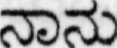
ನಾನು
